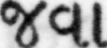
જવા
